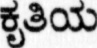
ಕೃತಿಯ
